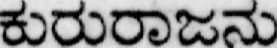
ಕುರುರಾಜನು
